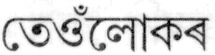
তেওঁলোকৰ
